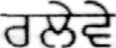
ਰਲੇਵੇ
